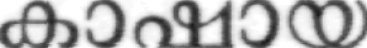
കാഷായ
